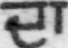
ਦਾ
